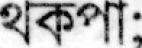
থকপা;
